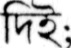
দিই;
